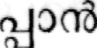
പ്പാന്‍
